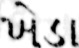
ખેડા
